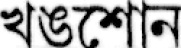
খঙশোন
